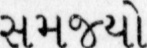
સમજ્યો
